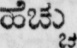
ಹೆಚ್ಚು
